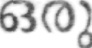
ഒരു
